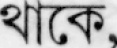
থাকে,
